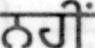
ਨਹੀਂ
